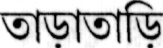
তাড়াতাড়ি
